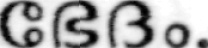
ഭേദം.
